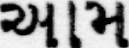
આમ
